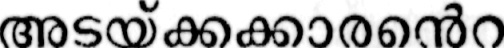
അടയ്ക്കക്കാരന്റെ
